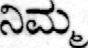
ನಿಮ್ಮ
